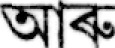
আৰু
